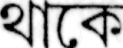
থাকে
